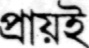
প্রায়ই
